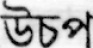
উচপ
